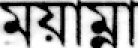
ময়াম্না
